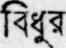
বিধুর
